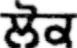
ਲੋਕ
